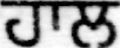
ਹਾਲ
